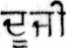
ਦੂਜੀ
